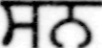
ਸਨ
